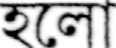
হলো
